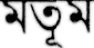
মতূম
